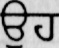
ਉਹ
